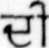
ਦੀ
